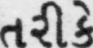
તરીકે
